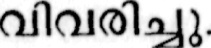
വിവരിച്ചു.
